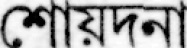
শোয়দনা
